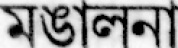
মঙালনা
